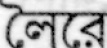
লৈরে
